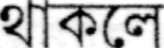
থাকলে
